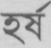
হর্ষ
